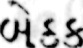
બેઠક
